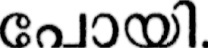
പോയി.
